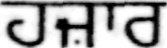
ਹਜ਼ਾਰ
